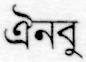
ঐনবু
